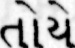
તોયે
